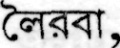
লৈরবা,
